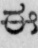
ಈ
